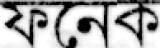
ফনেক
